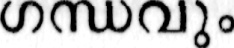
ഗന്ധവും
